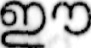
ഈ
